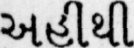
અહીંથી
